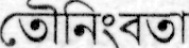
তৌনিংবতা
